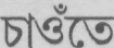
চাওঁতে
